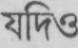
যদিও
